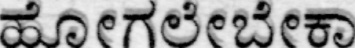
ಹೋಗಲೇಬೇಕಾ
